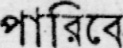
পারিবে
